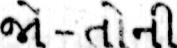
જો-તોની
